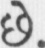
છે.
